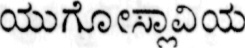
ಯುಗೋಸ್ಲಾವಿಯ
